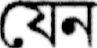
যেন
